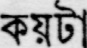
কয়টা
